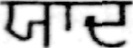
ਯਾਦ
